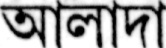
আলাদা
